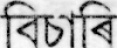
বিচাৰি
